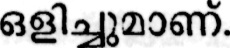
ഒളിച്ചുമാണ്.
